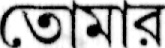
তোমার
